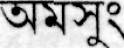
অমসুং
